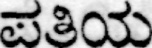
ಪತಿಯ
